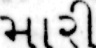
મારી
